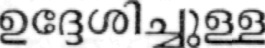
ഉദ്ദേശിച്ചുള്ള
